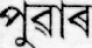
পুৱাৰ
